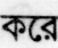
করে
